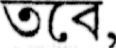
তবে,
